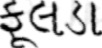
ફૂલડા
